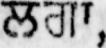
ਲਗਾ,
